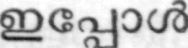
ഇപ്പോള്‍
